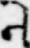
ને
